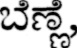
ಬೆಣ್ಣೆ,
